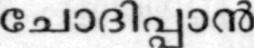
ചോദിപ്പാന്‍
